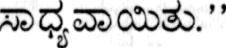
ಸಾಧ್ಯವಾಯಿತು."
